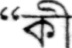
“কী
